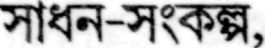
সাধন-সংকল্প,
